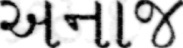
અનાજ
